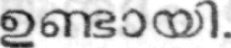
ഉണ്ടായി.
